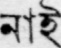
নাই
